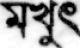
মখুৎ
